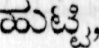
ಹುಟ್ಟಿ,
